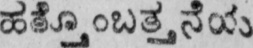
ಹತ್ತೊಂಬತ್ತನೆಯ
